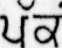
ਪੱਕ
